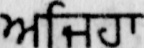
ਅਜਿਹਾ
